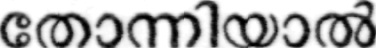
തോന്നിയാല്‍
